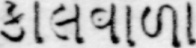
કાલવાળા
